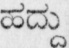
ಹದ್ದು
